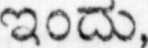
ಇಂದು,
